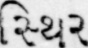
સ્થિર
